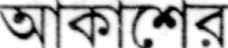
আকাশের
